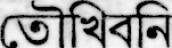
তৌখিবনি
